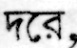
দরে,
